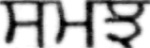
ਸਮਝ
